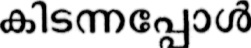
കിടന്നപ്പോള്‍
